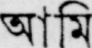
আমি
